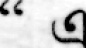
“এ
